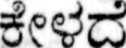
ಕೇಳದೆ
